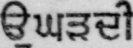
ਉਘੜਦੀ
